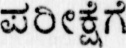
ಪರೀಕ್ಷೆಗೆ
